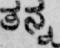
ತನ್ನ
